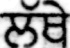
ਲੱਥੇ
